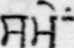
ਸਮੇਂ
